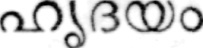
ഹൃദയം
